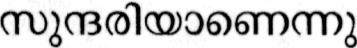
സുന്ദരിയാണെന്നു
